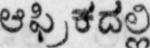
ಆಫ್ರಿಕದಲ್ಲಿ
